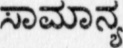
ಸಾಮಾನ್ಯ
